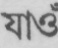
যাওঁ
